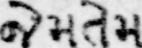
જેમતેમ
